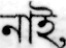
নাই,
